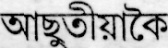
আছুতীয়াকৈ
